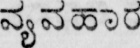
ವ್ಯವಹಾರ
